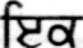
ਇਕ
